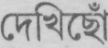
দেখিছোঁ
